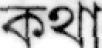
কথা
